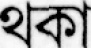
থকা
